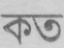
কত
